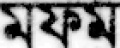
মফম
